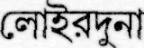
লোইরদুনা
